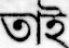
তাই
